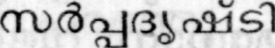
സര്‍പ്പദൃഷ്ടി
